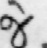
જે.
